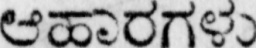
ಆಹಾರಗಳು
